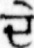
ਦੇ
